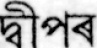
দ্বীপৰ
